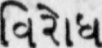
વિરોધ
